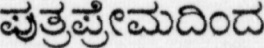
ಪುತ್ರಪ್ರೇಮದಿಂದ
